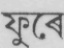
ফুৰে
